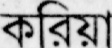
করিয়া
